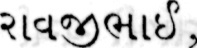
રાવજીભાઈ,
